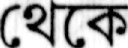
থেকে
